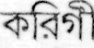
করিগী
